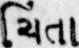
ચિંતા
